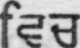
ਵਿਚ
